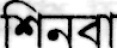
শিনবা
